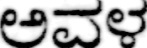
ಅವಳ
